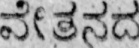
ವೇತನದ
